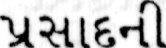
પ્રસાદની
